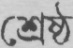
শ্ৰেষ্ঠ
